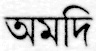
অমদি
